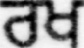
ਰਖ
